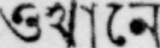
ওখানে
